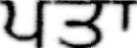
ਪਤਾ
